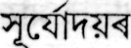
সূর্যোদয়ৰ
